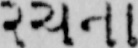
રચના
